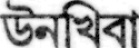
উনখিবা
